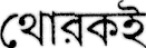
থোরকই
